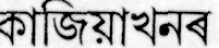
কাজিয়াখনৰ
